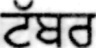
ਟੱਬਰ
